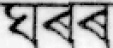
ঘৰৰ
